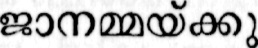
ജാനമ്മയ്ക്കു
